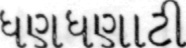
ધણધણાટી
